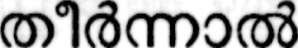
തീര്‍ന്നാല്‍
